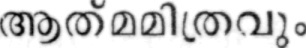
ആത്മമിത്രവും
